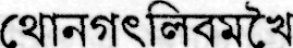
থোনগৎলিবমখৈ
